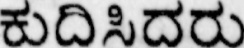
ಕುದಿಸಿದರು
